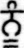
ਨੂੰ
